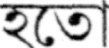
হতো
